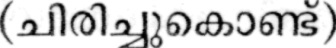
(ചിരിച്ചുകൊണ്ട്)
